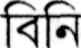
বিনি
